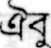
ঐবু
